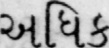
અધિક
